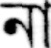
না
